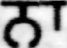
ਨਾ
